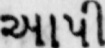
આપી
